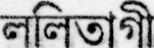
ললিতাগা
